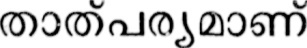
താത്പര്യമാണ്
